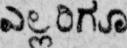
ಎಲ್ಲರಿಗೂ
